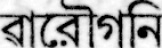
ৱারৌগনি
